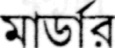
মার্ডার
